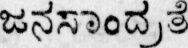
ಜನಸಾಂದ್ರತೆ
